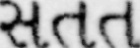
સતત
